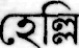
হেল্লি
